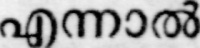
എന്നാല്‍
